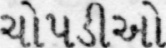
ચોપડીઓ
